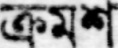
ক্রমশ
